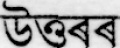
উত্তৰৰ
